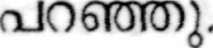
പറഞ്ഞു.
